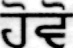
ਹੋਵੋ
